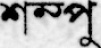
শম্পু
